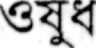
ওষুধ
